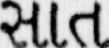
સાત
